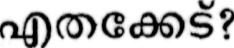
എതക്കേട്?
